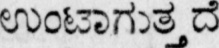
ಉಂಟಾಗುತ್ತದೆ
